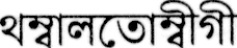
থম্বালতোম্বীগী
